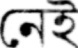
নেই
